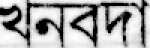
খনবদা
